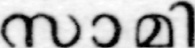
സാമി
